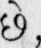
છે,
